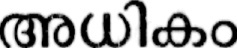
അധികം
